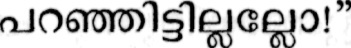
പറഞ്ഞിട്ടില്ലല്ലോ!”
